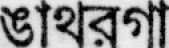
ঙাথরগা
